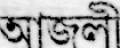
আজলী
